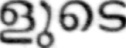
ളുടെ
